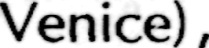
Venice),
